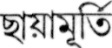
ছায়ামূর্তি
